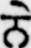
ਨੇ
